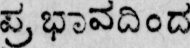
ಪ್ರಭಾವದಿಂದ
